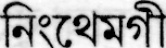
নিংথেমগী
